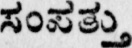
ಸಂಪತ್ತು
